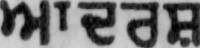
ਆਦਰਸ਼
